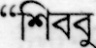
“শিববু
